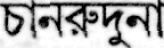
চানরুদুনা
